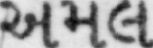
અમલ
